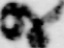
જ
